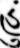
હું
